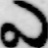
ಎ
